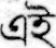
এই
